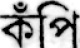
কঁপি
